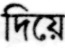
দিয়ে
